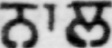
ਨਾਲ
